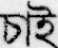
চাই
